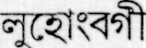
লুহোংবগী
